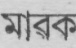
মাৱক
